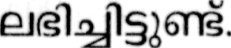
ലഭിച്ചിട്ടുണ്ട്.
